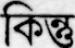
কিন্তু
